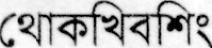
থোকখিবশিং
